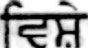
ਵਿਸ਼ੇ
